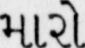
મારો
